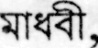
মাধবী,
